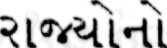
રાજ્યોનો
